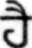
ਹੈ
